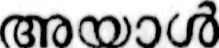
അയാള്‍
